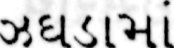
ઝઘડામાં
